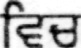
ਵਿਚ
